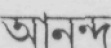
আনন্দ
